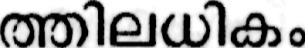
ത്തിലധികം
